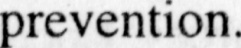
prevention.
